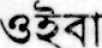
ওইবা
